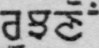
ਰੁਝਣੋਂ
